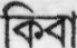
কিবা
